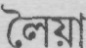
লৈয়া
